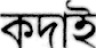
কদাই
